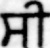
ਸੀ
